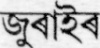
জুৰাইৰ
